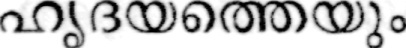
ഹൃദയത്തെയും
